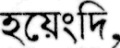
হয়েংদি,
